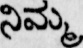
ನಿಮ್ಮ
